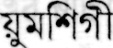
য়ুমশিগী
